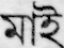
মাই
